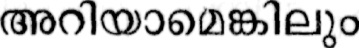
അറിയാമെങ്കിലും
